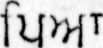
ਪਿਆ
